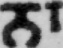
ਨਾ
